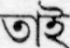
তাই
